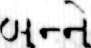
બન્ને
